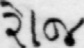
રોજ
